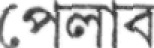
পেলাব
